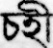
চহী
